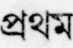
প্রথম
